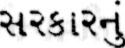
સરકારનું
